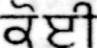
ਕੋਈ
